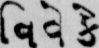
વિવેકે
